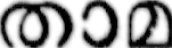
താമ
